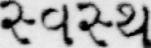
સ્વસ્થ
